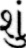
શું
